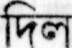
দিল
